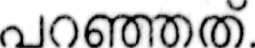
പറഞ്ഞത്.
